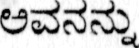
ಅವನನ್ನು
